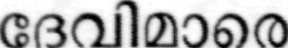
ദേവിമാരെ
